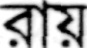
রায়
